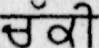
ਚੱਕੀ
